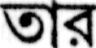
তার
